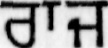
ਰਾਜ
